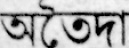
অতৈদা
